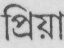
প্ৰিয়া
